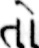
તો
